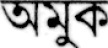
অমুক
